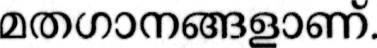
മതഗാനങ്ങളാണ്.
